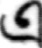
এ
